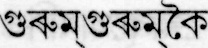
গুৰুম্‌গুৰুম্‌কৈ
